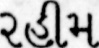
રહીમ
